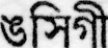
ঙসিগী
